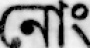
নোং
